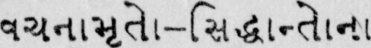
વચનામૃતો-સિદ્ધાન્તોના
